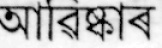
আৱিস্কাৰ
